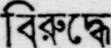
বিরুদ্ধে
